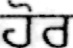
ਹੋਰ
